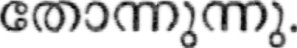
തോന്നുന്നു.
